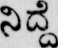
ನಿದ್ದೆ
